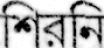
শিরনি
